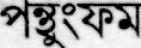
পন্থুংফম
